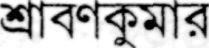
শ্রাবণকুমার
